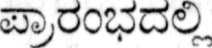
ಪ್ರಾರಂಭದಲ್ಲಿ
